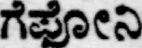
ಗೆಫೋನಿ
